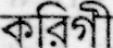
করিগী
